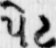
પેટ'
